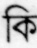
কি
